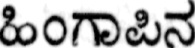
ಹಿಂಗಾಪಿನ
